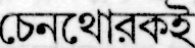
চেনথোরকই
